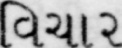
વિચાર
